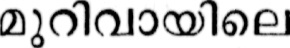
മുറിവായിലെ
